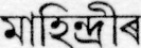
মাহিন্দ্রীৰ
